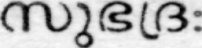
സുഭദ്ര:
